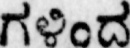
ಗಳಿಂದ
